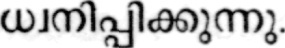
ധ്വനിപ്പിക്കുന്നു.
